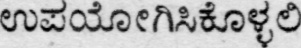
ಉಪಯೋಗಿಸಿಕೊಳ್ಳಲಿ
